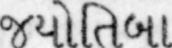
જ્યોતિબા
